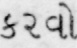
કરવો
